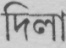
দিলা
